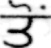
ਤੋਂ
